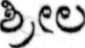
ಶ್ರೀಲ
